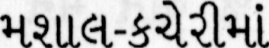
મશાલ-કચેરીમાં
